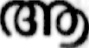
ആ
